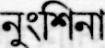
নুংশিনা
